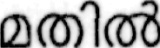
മതില്‍
